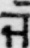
ਜੋ
